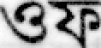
ওফ
